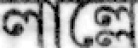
লাল্লে
